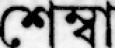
শেম্বা
